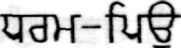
ਧਰਮ-ਪਿਉ
